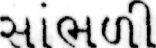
સાંભળી
